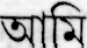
আমি
